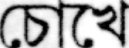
চোখে
